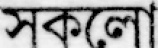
সকলো
